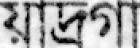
য়াদ্রগা
